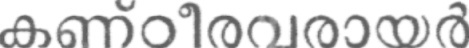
കണ്ഠീരവരായര്‍
